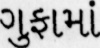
ગુફામાં
